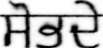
ਸੋਭਦੇ
